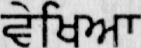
ਵੇਖਿਆ
